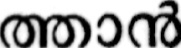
ത്താന്‍
